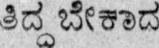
ತಿದ್ದಬೇಕಾದ
